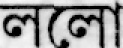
ললো
